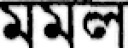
মমল
